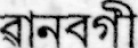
ৱানবগী
